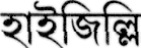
হাইজিল্লি
